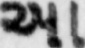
આ
